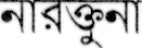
নারক্তুনা
